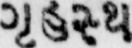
ગૃહસ્થ
